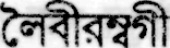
লৈবীরম্বগী
